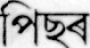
পিছৰ
